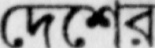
দেশের
